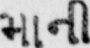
માની
